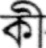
কী
